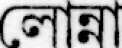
লোন্না
